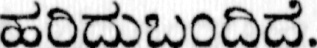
ಹರಿದುಬಂದಿದೆ.
